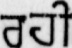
ਰਹੀ
